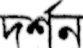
দর্শন
